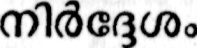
നിര്‍ദ്ദേശം
